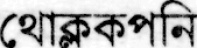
থোক্লকপনি
